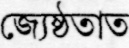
জ্যেষ্ঠতাত
